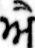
ਐ
